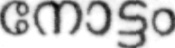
നോട്ടം
